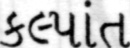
કલ્પાંત
